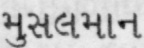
મુસલમાન
